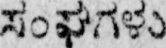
ಸಂಘಗಳು
